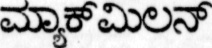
ಮ್ಯಾಕ್‌ಮಿಲನ್
